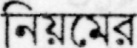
নিয়মের
